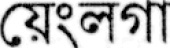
য়েংলগা
